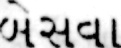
બેસવા
